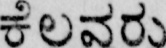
ಕೆಲವರು
